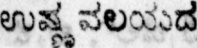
ಉಷ್ಣವಲಯದ
